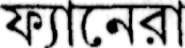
ফ্যানেরা
